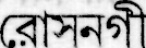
রোসনগী
